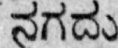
ನಗದು
